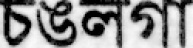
চঙলগা
